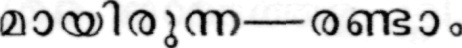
മായിരുന്ന-രണ്ടാം
